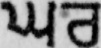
ਘਰ
